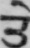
ਤੇ
